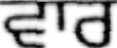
ਵਾਰ
